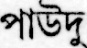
পাউদু
